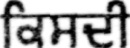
ਕਿਸਦੀ
